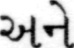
અને
